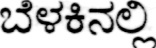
ಬೆಳಕಿನಲ್ಲಿ
